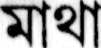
মাথা
